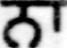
ਨਾ
